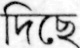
দিছে
